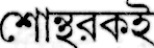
শোন্থরকই
